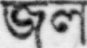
জল
